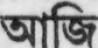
আজি
